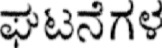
ಘಟನೆಗಳ
